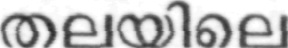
തലയിലെ
